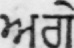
ਅਗੇ
